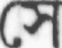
সে
